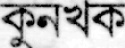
কুনখক
